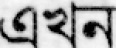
এখন
